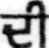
ਦੀ
